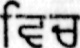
ਵਿਚ
